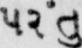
પરંતુ
